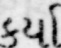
કર્યા
